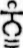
ਨੂੰ
